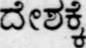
ದೇಶಕ್ಕೆ
